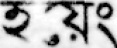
হয়েং
